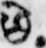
છે.
